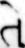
તે
